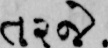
તરજે.
